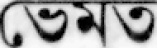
ভেমত
